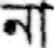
না
